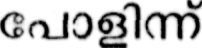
പോളിന്ന്
